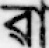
ৱা
